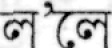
ল'লে
